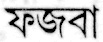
ফজবা
